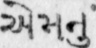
એમનું
